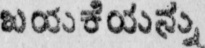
ಬಯಕೆಯನ್ನು
